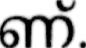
ണ്.
